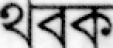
থবক
